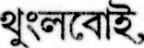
থুংলবোই,
